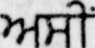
ਅਸੀਂ
